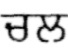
ਚਲ
